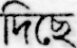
দিছে
